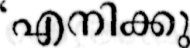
‘എനിക്കു
